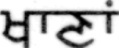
ਖਾਣਾਂ
